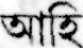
আহি
